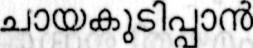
ചായകുടിപ്പാന്‍
